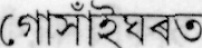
গোসাঁইঘৰত
